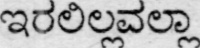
ಇರಲಿಲ್ಲವಲ್ಲಾ
